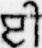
ਈ
